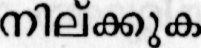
നില്ക്കുക
